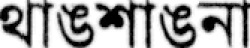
থাঙশাঙনা
